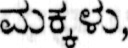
ಮಕ್ಕಳು,
